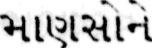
માણસોને
